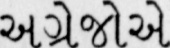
અંગ્રેજોએ
